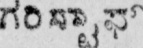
ಗರಿಸ್ಟಾಫ್
